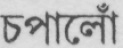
চপালোঁ
